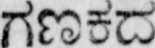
ಗಣಕದ
